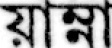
য়াম্না
